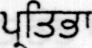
ਪ੍ਰਤਿਭਾ
